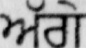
ਅੱਗੇ
